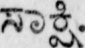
ಸಾಕ್ಷಿ.
